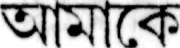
আমাকে
